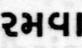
રમવા
